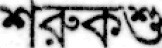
শরুকশু
